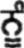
ਨੂੰ
